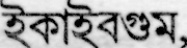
ইকাইবগুম,
